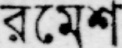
রমেশ
